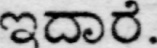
ಇದಾರೆ.
